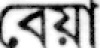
বেয়া
